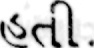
હતી.
